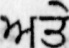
ਅਤੇ
